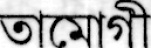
তামোগী
